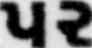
પર
